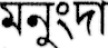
মনুংদা
